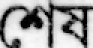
শেষ
